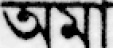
অমা
